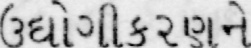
ઉદ્યોગીકરણને
